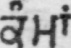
ਕੰਮਾਂ
